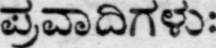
ಪ್ರವಾದಿಗಳು:
